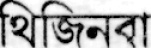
থিজিনবা
